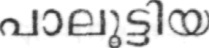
പാലൂട്ടിയ
